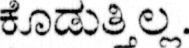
ಕೊಡುತ್ತಿಲ್ಲ.
